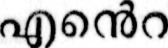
എന്റെ
